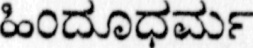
ಹಿಂದೂಧರ್ಮ
